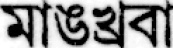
মাঙখ্রবা
